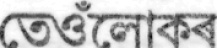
তেওঁলোকৰ
